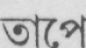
তাপে
